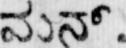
ಮನ್.
